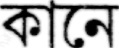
কানে
